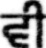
ਵੀ
